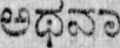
ಅಥವಾ
